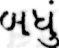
બધું
